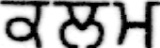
ਕਲਮ
